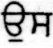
ਉਸ
